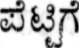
ಪೆಟ್ಟಿಗೆ
